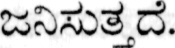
ಜನಿಸುತ್ತದೆ.
